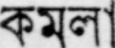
কমলা
